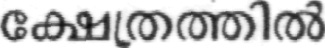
ക്ഷേത്രത്തില്‍
